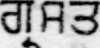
ਗ੍ਰਸਤ
